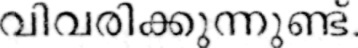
വിവരിക്കുന്നുണ്ട്.
